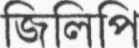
জিলিপি
